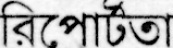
রিপোর্টতা
